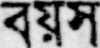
বয়স
